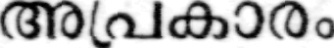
അപ്രകാരം
